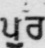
ਪੁਰ
